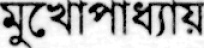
মুখোপাধ্যায়
